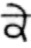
ਕੇ
